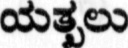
ಯತ್ಖಲು
